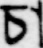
চা
